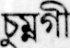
চুম্নগী
